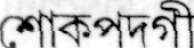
শোকপদগী
